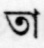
তা
